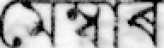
মেম্বাৰ
